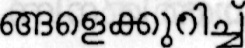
ങ്ങളെക്കുറിച്ച്
